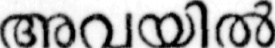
അവയില്‍
